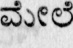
ಮೇಲೆ
